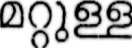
മറ്റുള്ള
